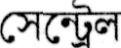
সেন্ট্রেল
